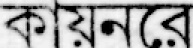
কায়নরে
